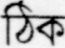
ঠিক
